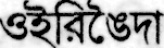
ওইরিঙৈদা
